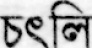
চৎলি
